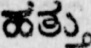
ಹತ್ತು
